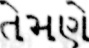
તેમણે
